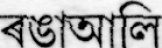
ৰঙাআলি
